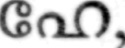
ഹേ,
